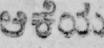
ಆಕೆಯ
